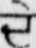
ਦੇ
